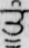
ਤੂੰ
